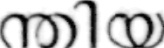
ന്തിയ
